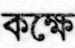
কক্ষে
